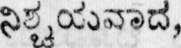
ನಿಶ್ಚಯವಾದ,
